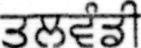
ਤਲਵੰਡੀ
